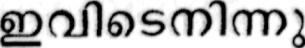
ഇവിടെനിന്നു
